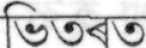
ভিতৰত
